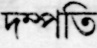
দম্পতি
